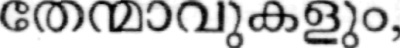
തേന്മാവുകളും,
